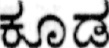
ಕೂಡ
